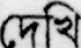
দেখি
